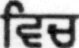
ਵਿਚ
